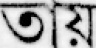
তায়
